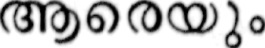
ആരെയും
